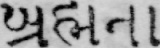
બ્રહ્મના
